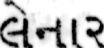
લેનાર
